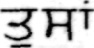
ਤੁਸਾਂ
